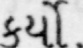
કર્યો.
